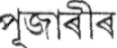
পূজাৰীৰ
